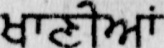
ਖਾਣੀਆਂ
